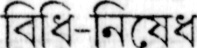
বিধি-নিষেধ
